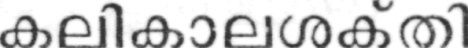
കലികാലശക്തി
